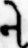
ને
